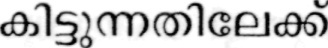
കിട്ടുന്നതിലേക്ക്
